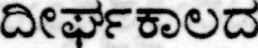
ದೀರ್ಘಕಾಲದ
